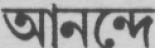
আনন্দে
